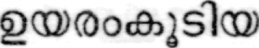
ഉയരംകൂടിയ
